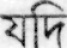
যদি
